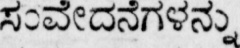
ಸಂವೇದನೆಗಳನ್ನು
